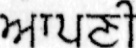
ਆਪਣੀ
